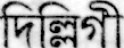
দিল্লিগী
